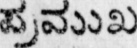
ಪ್ರಮುಖ
